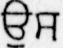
ਉਸ
